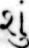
શું
